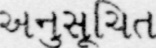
અનુસૂચિત
